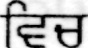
ਵਿਚ
